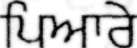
ਪਿਆਰੇ
